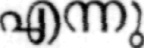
എന്നു
